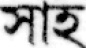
সাহ
